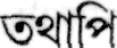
তথাপি
